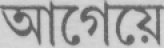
আগেয়ে
